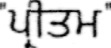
''ਪ੍ਰੀਤਮ''
